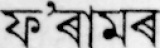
ফ'ৰামৰ
